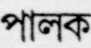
পালক
